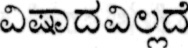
ವಿಷಾದವಿಲ್ಲದೆ
